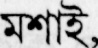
মশাই,
